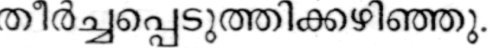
തീര്‍ച്ചപ്പെടുത്തിക്കഴിഞ്ഞു.
